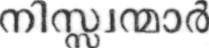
നിസ്സ്വന്മാര്‍
